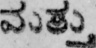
ಮತ್ತು
